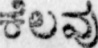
ಕೆಲವು
